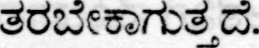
ತರಬೇಕಾಗುತ್ತದೆ.
